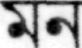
মন
